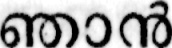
ഞാന്‍
